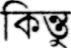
কিন্তু
